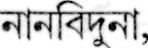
নানবিদুনা,
